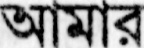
আমার
